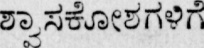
ಶ್ವಾಸಕೋಶಗಳಿಗೆ
